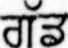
ਗੱਡ
